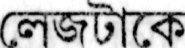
লেজটাকে
